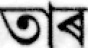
তাৰ
